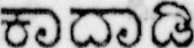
ಕಾದಾಡಿ
